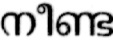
നീണ്ട
